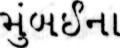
મુંબઈના
